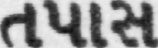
તપાસ
